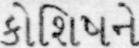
કોશિષને
